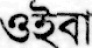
ওইবা
